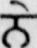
ਨੇ
